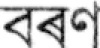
বৰণ
